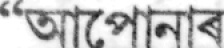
"আপোনাৰ
